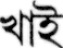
খাই
